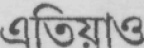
এতিয়াও
